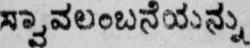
ಸ್ವಾವಲಂಬನೆಯನ್ನು
